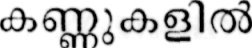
കണ്ണുകളില്‍
